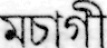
মচাগী
